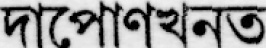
দাপোণখনত
